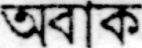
অবাক
